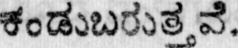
ಕಂಡುಬರುತ್ತವೆ.
